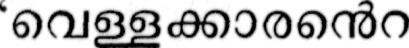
‘വെള്ളക്കാരന്റെ
